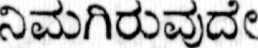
ನಿಮಗಿರುವುದೇ
